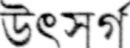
উত্সর্গ
